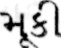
મૂકી
